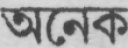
অনেক
